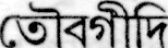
তৌবগীদি
